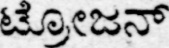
ಟ್ರೋಜನ್
